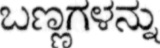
ಬಣ್ಣಗಳನ್ನು
